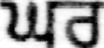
ਘਰ
